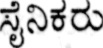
ಸೈನಿಕರು
